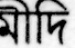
মীদি
